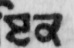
ਇਕ
